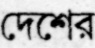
দেশের
